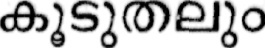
കൂടുതലും
